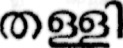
തള്ളി
